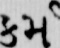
કર્મ
